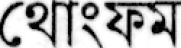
থোংফম
